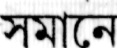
সমানে
